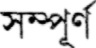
সম্পূর্ণ
